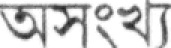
অসংখ্য
